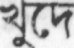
খুদে
